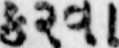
કરવા
